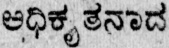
ಅಧಿಕೃತನಾದ
